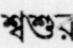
শ্বশুর
